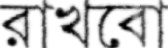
রাখবো
